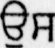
ਉਸ
